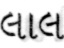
લાલ
